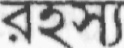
রহস্য
